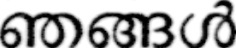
ഞങ്ങള്‍
